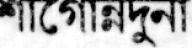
শাগোন্নদুনা
